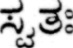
ಸ್ವತಃ
